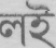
লই
